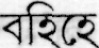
বহিহে
